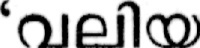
'വലിയ
